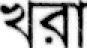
খরা
